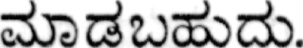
ಮಾಡಬಹುದು.
